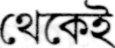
থেকেই
